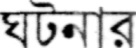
ঘটনার
